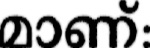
മാണ്:
